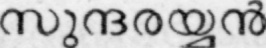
സുന്ദരയ്യന്‍
